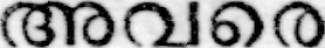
അവരെ
